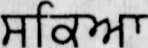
ਸਕਿਆ
